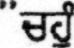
''ਚਹੁੰ
